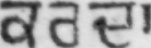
ਕਰਦਾ
